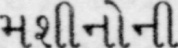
મશીનોની
